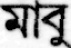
মাবু
